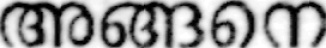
അങ്ങനെ
